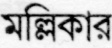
মল্লিকার
